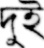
দুই
